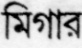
মিগার
